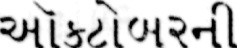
ઑક્ટોબરની
